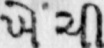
ખેંચી
